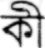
কী
